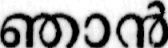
ഞാന്‍
